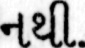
નથી.
